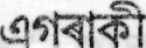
এগৰাকী
